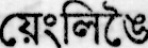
য়েংলিঙৈ
